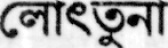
লোৎতুনা
